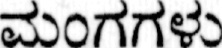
ಮಂಗಗಳು
